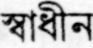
স্বাধীন
